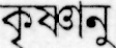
কৃষ্ণানু
